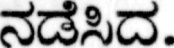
ನಡೆಸಿದ.
